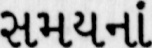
સમયનાં
